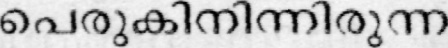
പെരുകിനിന്നിരുന്ന
